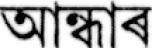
আন্ধাৰ
